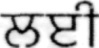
ਲਈ
